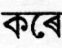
কৰে
